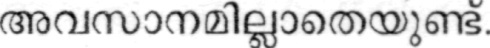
അവസാനമില്ലാതെയുണ്ട്.
